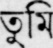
তুমি
